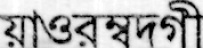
য়াওরম্বদগী
